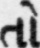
તો
